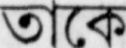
তাকে
